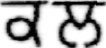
ਕਲ
